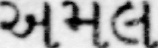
અમલ
